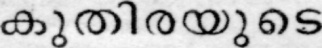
കുതിരയുടെ
